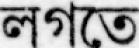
লগতে
